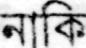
নাকি
